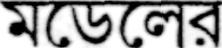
মডেলের
